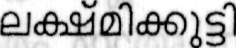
ലക്ഷ്മിക്കുട്ടി
